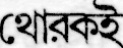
থোরকই
